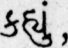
કહ્યું,
